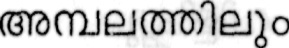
അമ്പലത്തിലും
